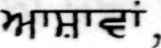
ਆਸ਼ਾਵਾਂ,
